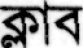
ক্লাব
